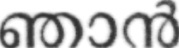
ഞാന്‍
